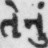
તેનું
